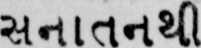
સનાતનથી
